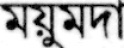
ময়ুমদা
